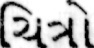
ચિત્રો
